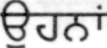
ਉਹਨਾਂ
